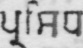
ਪ੍ਰਸਿਧ
